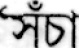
'সঁচা
